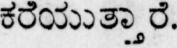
ಕರೆಯುತ್ತಾರೆ.
